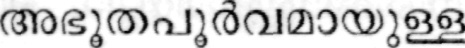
അഭൂതപൂര്‍വമായുള്ള
